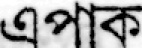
এপাক
